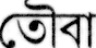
তৌবা
